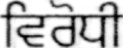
ਵਿਰੋਧੀ
